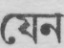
যেন
